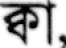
ক্বা,
